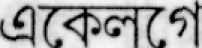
একেলগে
